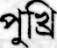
পুখ্রি
